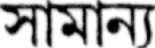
সামান্য
